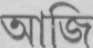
আজি
